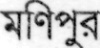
মণিপুর
